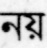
নয়
